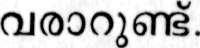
വരാറുണ്ട്.
